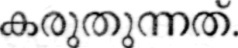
കരുതുന്നത്.
